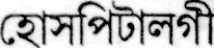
হোসপিটালগী
